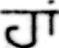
ਹਾਂ
